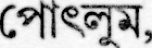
পোৎলুম,
